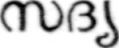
സദ്യ
